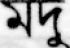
মদু
